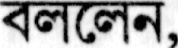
বললেন,
